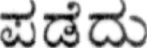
ಪಡೆದು
